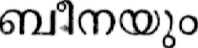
ബീനയും
